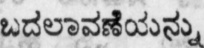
ಬದಲಾವಣೆಯನ್ನು
